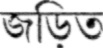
জড়িত
